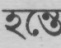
হন্তে
